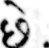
છે.
